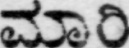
ಮಾರಿ
